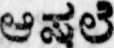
ಆಷಲೆ
